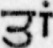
ਤਾਂ
